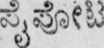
ಪೈಪೋಟಿ
